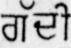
ਗੱਦੀ
